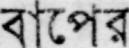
বাপের
